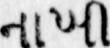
નાખી
